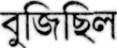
বুজিছিল
